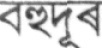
বহুদূৰ
